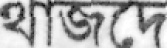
থাজদে
